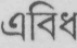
এবিধ
